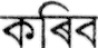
কৰিব
